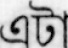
এটা
